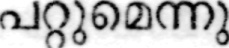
പറ്റുമെന്നു
